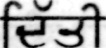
ਦਿੱਤੀ
